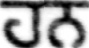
ਹਨ
